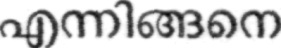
എന്നിങ്ങനെ
